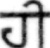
ਹੀ
